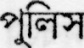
পুলিস
